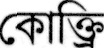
কোক্ত্রি
